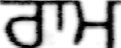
ਰਾਮ
